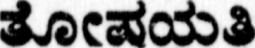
ತೋಷಯತಿ
